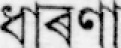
ধাৰণা
